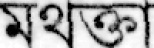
মথক্তা
